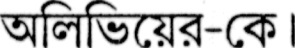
অলিভিয়ের-কে।
